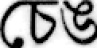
চেঙ
